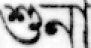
শুনা
